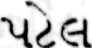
પટેલ
